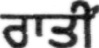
ਰਾਤੀਂ
